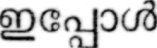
ഇപ്പോള്‍
